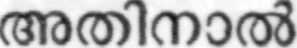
അതിനാല്‍
